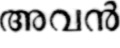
അവന്‍
